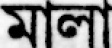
মালা
